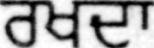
ਰਖਦਾ
